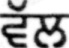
ਵੱਲ
